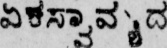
ಏಕಸ್ವಾಮ್ಯದ
